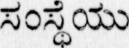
ಸಂಸ್ಥೆಯು
